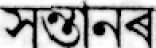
সন্তানৰ
